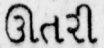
ઊતરી
